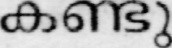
കണ്ടു
